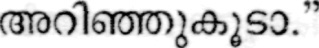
അറിഞ്ഞുകൂടാ.”
